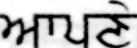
ਆਪਣੇ
